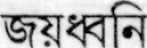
জয়ধ্বনি
